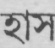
হাস
